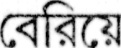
বেরিয়ে
